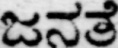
ಜನತೆ
